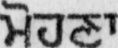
ਮੋਹਣਾ
